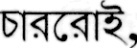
চাররোই,
